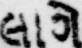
લાગે
